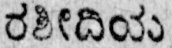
ರಶೀದಿಯ
